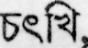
চৎখি,
